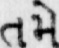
તમે
